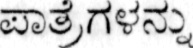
ಪಾತ್ರೆಗಳನ್ನು
